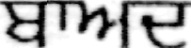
ਬਾਅਦ
